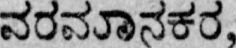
ವರಮಾನಕರ,
